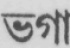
ভগা
